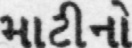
માટીનો
